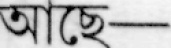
আছে-
